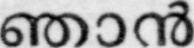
ഞാന്‍
